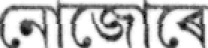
নোজোৰে
